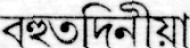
বহুতদিনীয়া
